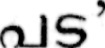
പട’
